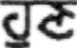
ਹੁਣ
